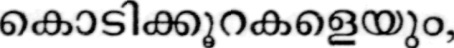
കൊടിക്കൂറകളെയും,
